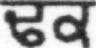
ਢਕ
